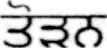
ਤੋੜਨ
